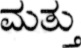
ಮತ್ತು
